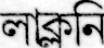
লাক্লনি
